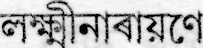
লক্ষ্মীনাৰায়ণে
